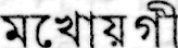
মখোয়গী
